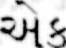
એક
